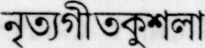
নৃত্যগীতকুশলা
